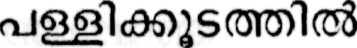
പള്ളിക്കൂടത്തില്‍
